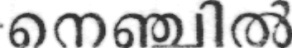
നെഞ്ചില്‍
